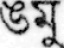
ঙমু
